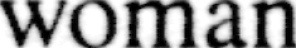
WOman
